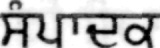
ਸੰਪਾਦਕ
